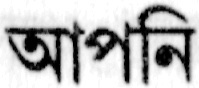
আপনি
